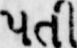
પતી
